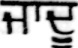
ਜਾਦੂ
